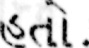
હતો.
